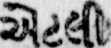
એટલી
